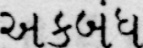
અકબંધ
